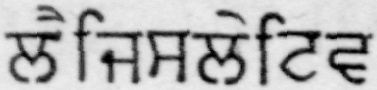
ਲੈਜਿਸਲੇਟਿਵ
